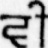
ਵੀ
